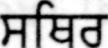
ਸਥਿਰ
